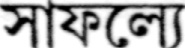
সাফল্যে
